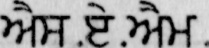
ਐਸ.ਏ.ਐਮ.
